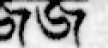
জজ
